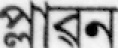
প্লাৱন
